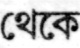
থেকে
